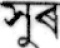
সুৰ
